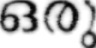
ഒരു
